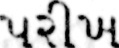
પરીખ
